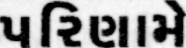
પરિણામે
